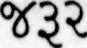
જરૂર
